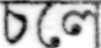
চলে
